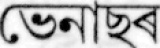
ভেনাছৰ
